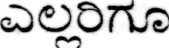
ಎಲ್ಲರಿಗೂ
